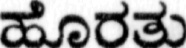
ಹೊರತು
